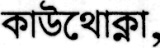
কাউথোক্না,
